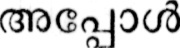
അപ്പോള്‍
